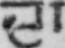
ਦਾ
